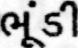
ભૂંડી
